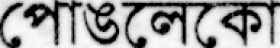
পোঙলেকো
